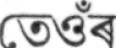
তেওঁৰ
